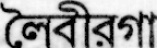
লৈবীরগা
